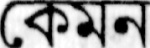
কেমন
